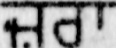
ਜ਼ਰਾ
